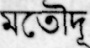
মতৌদূ
